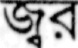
জ্বর
